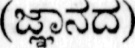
(ಜ್ಞಾನದ)
